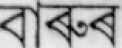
বাৰুৰ
